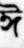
ঈ
